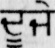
ਦੂਜੇ
